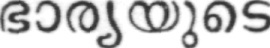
ഭാര്യയുടെ
